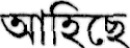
আহিছে
